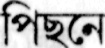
পিছনে
